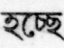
হচ্ছে
